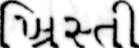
ખ્રિસ્તી
